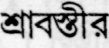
শ্রাবস্তীর
